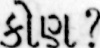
કોણ?
